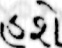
હશે
